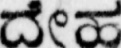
ದೇಹ
